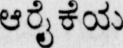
ಆರೈಕೆಯ
